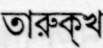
তারুক্খ
